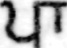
ਪਾ
